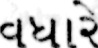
વધારે
